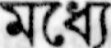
মধ্যে
